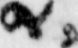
જ
